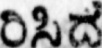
ರಿಸಿದ
